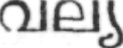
വല്യ
